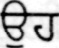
ਉਹ
